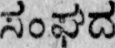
ಸಂಘದ
